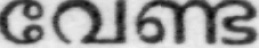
വേണ്ട
